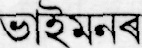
ভাইমনৰ
